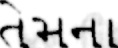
તેમના
